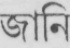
জানি
